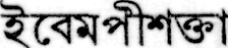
ইবেমপীশক্তা
